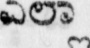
ಎಲ್ಲಾ
